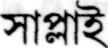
সাপ্লাই
